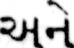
અને
